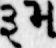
રૂમ
